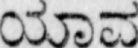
ಯಾವ
